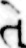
તે
